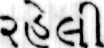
રહેલી
